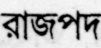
রাজপদ
